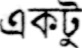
একটু
